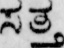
ಸತ್ತ
